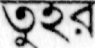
তুহর
